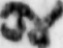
જ
